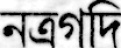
নত্রগদি
